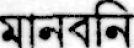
মানবনি
